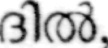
ദില്‍,
